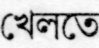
খেলতে
